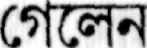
গেলেন
